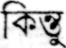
কিন্তু
